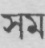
সম
